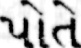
પોતે
